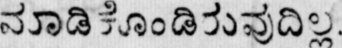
ಮಾಡಿಕೊಂಡಿರುವುದಿಲ್ಲ.
